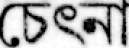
চেৎনা
